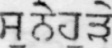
ਸੁਨੇਹੁੜੇ
